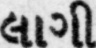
લાગી
